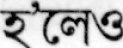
হ'লেও
